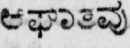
ಆಘಾತವು
